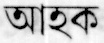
আহক
